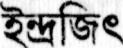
ইন্দ্রজিৎ
